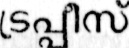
ട്രപ്പീസ്
